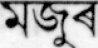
মজুৰ
